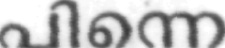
പിന്നെ
